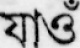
যাওঁ
